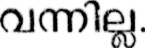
വന്നില്ല.
